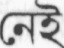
নেই
